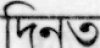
দিনত
